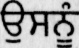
ਉਸਨੂੰ
